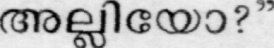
അല്ലിയോ?"
